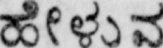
ಹೇಳುವ
